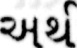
અર્થ
